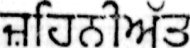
ਜ਼ਹਿਨੀਅੱਤ
